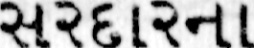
સરદારના
